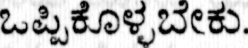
ಒಪ್ಪಿಕೊಳ್ಳಬೇಕು.
